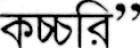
কচ্চরি”
